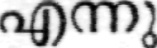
എന്നു
